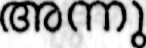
അന്നു
